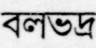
বলভদ্র
